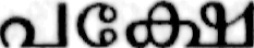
പക്ഷേ
